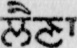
ਲੈਣਾ
